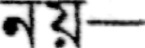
নয়–
